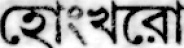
হোংখরো
